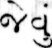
જેવું
